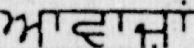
ਆਵਾਜ਼ਾਂ
